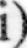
i)
